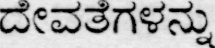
ದೇವತೆಗಳನ್ನು
